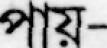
পায়-
